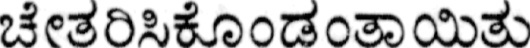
ಚೇತರಿಸಿಕೊಂಡಂತಾಯಿತು
